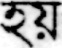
হয়
